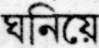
ঘনিয়ে
